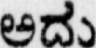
ಅದು
